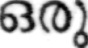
ഒരു
